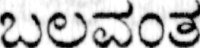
ಬಲವಂತ
